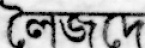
লৈজদে
